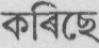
কৰিছে
